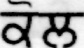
ਕੋਲ
